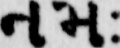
નમઃ
